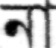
না
